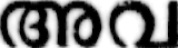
അവ
